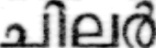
ചിലര്‍
